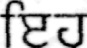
ਇਹ
